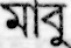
মাবু
